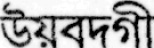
উয়বদগী
